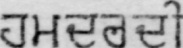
ਹਮਦਰਦੀ
